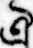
ঐ
